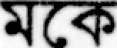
মকে
